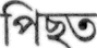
পিছত
